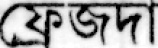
ফ্রেজদা
